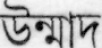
উন্মাদ
